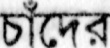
চাঁদের
